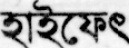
হাইফেৎ
